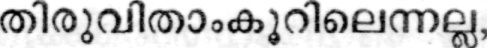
തിരുവിതാംകൂറിലെന്നല്ല,
